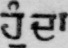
ਹੁੰਦਾ
